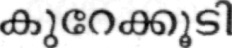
കുറേക്കൂടി
